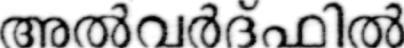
അല്‍വര്‍ദ്ഫില്‍
